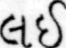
લઈ
